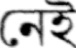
নেই
